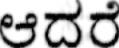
ಆದರೆ
